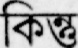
কিন্তু
